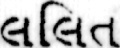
લલિત
